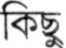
কিছু
